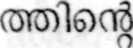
ത്തിന്റെ
